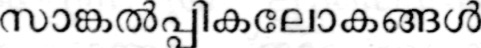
സാങ്കല്‍പ്പികലോകങ്ങള്‍
